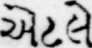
એટલે
